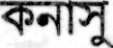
কনাসু
